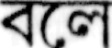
বলে
